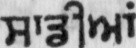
ਸਾਡੀਆਂ
